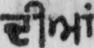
ਦੀਆਂ
